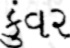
કુંવર
